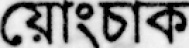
য়োংচাক
